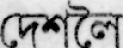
দেশলৈ
